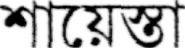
শায়েস্তা
